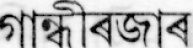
গান্ধীৰজাৰ
